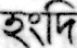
হংদি
